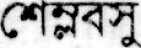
শেম্লবসু
